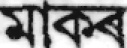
মাকৰ
